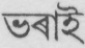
ভৰাই
